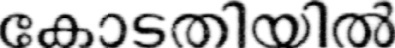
കോടതിയില്‍
